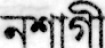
নশাগী
